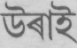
উৰাই
